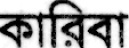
কারিবা
